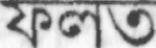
ফলত
